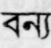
বন্য
